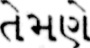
તેમણે
